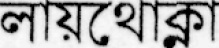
লায়থোক্না
